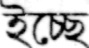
ইচ্ছে
